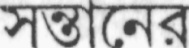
সন্তানের
